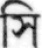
সি
